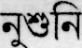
নুশুনি
